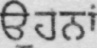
ਉਹਨਾਂ
